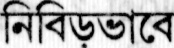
নিবিড়ভাবে
